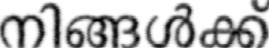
നിങ്ങള്‍ക്ക്
